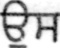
ਉਸ
